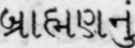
બ્રાહ્મણનું
